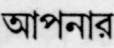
আপনার
